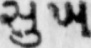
સુખ
